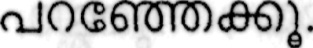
പറഞ്ഞേക്കൂ.
